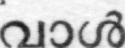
വാള്‍
